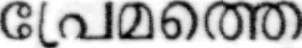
പ്രേമത്തെ
